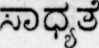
ಸಾಧ್ಯತೆ
